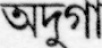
অদুগা
